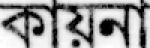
কায়না
